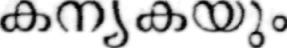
കന്യകയും
